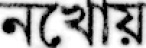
নখোয়
